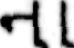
ના
